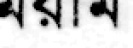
ময়াম
